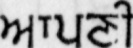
ਆਪਣੀ
